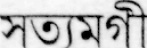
সত্যমগী
